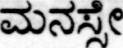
ಮನಸ್ಸೇ
